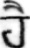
ਹੈ
